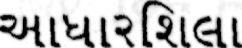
આધારશિલા
